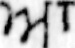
ਆ
